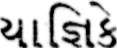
યાજ્ઞિકે
